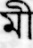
মী
